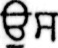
ਉਸ
